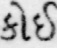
કોઈ
